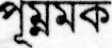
পূম্নমক
